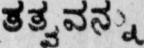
ತತ್ವವನ್ನು
